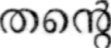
തന്റെ
